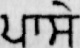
ਪਾਸੇ
